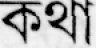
কথা
